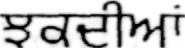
ਝਕਦੀਆਂ
